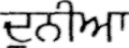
ਦੁਨੀਆ
